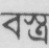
বস্ত্ৰ
